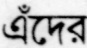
এঁদের
